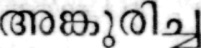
അങ്കുരിച്ച
